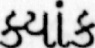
ક્યાંક
